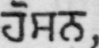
ਹੋਸਨ,
